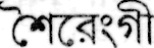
শৈরেংগী
